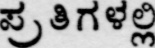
ಪ್ರತಿಗಳಲ್ಲಿ
